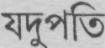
যদুপতি
